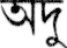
অদু
